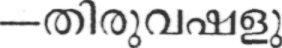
-തിരുവഷളു
